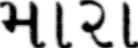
મારા
